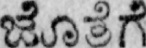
ಜೊತೆಗೆ
